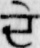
ਦੇ
